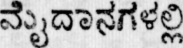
ಮೈದಾನಗಳಲ್ಲಿ
